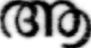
ആ
